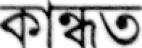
কান্ধত
